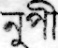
নুপী
